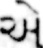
એ
